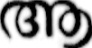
ആ
